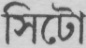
সিটো
